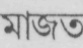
মাজত
